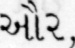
ઔર,
